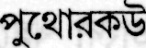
পুথোরকউ
